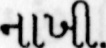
નાખી.
